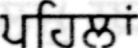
ਪਹਿਲਾਂ
